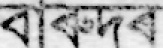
বাৰুদৰ
